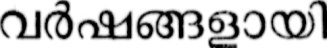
വര്‍ഷങ്ങളായി
